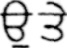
ਉਤੇ
